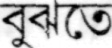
বুঝতে
